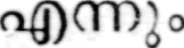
എന്നും
